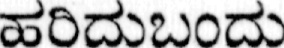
ಹರಿದುಬಂದು
